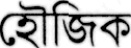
হৌজিক
